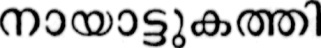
നായാട്ടുകത്തി
